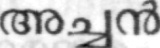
അച്ചന്‍
